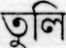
তুলি
